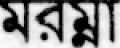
মরম্না
